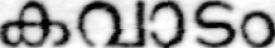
കവാടം
